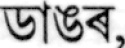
ডাঙৰ,
